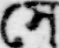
সে
